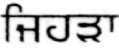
ਜਿਹੜਾ
